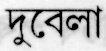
দুবেলা
